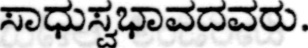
ಸಾಧುಸ್ವಭಾವದವರು.
